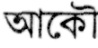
আকৌ
